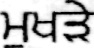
ਮੁਖੜੇ
